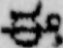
ಈ
